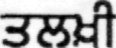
ਤਲਖ਼ੀ
